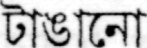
টাঙানো
